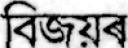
বিজয়ৰ
